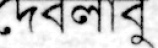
দেবলাবু
